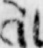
તો
